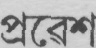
প্ৰৱেশ
